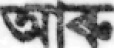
আৰু
